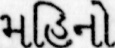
મહિનો
